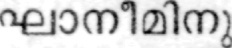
ഘാനീമിനു
